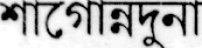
শাগোন্নদুনা
